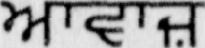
ਆਵਾਜ਼
